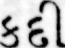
કદી
